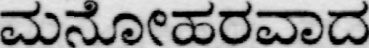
ಮನೋಹರವಾದ
